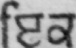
ਇਕ
